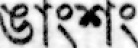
ঙাংশং
